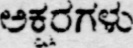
ಅಕ್ಷರಗಳು
